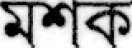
মশক
